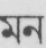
মন
